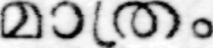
മാത്രം
